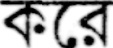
করে
